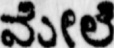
ಮೇಲೆ
